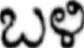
ಬಳಿ
